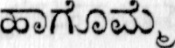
ಹಾಗೊಮ್ಮೆ
